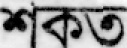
শকত
